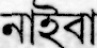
নাইবা
